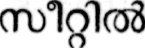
സീറ്റില്‍
